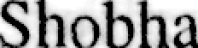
Shobha
